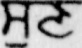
ਸੁਣ
